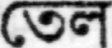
তেল
